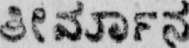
ತೀರ್ಮಾನ
